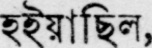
হইয়াছিল,
